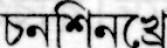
চনশিনখ্রে
